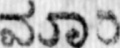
ಮಾರಿ
